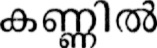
കണ്ണില്‍
